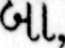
બા,
